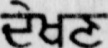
ਦੇਖਣ
